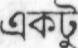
একটু
